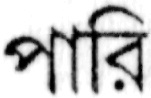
পারি
